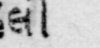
પહેલી
